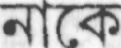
নাকে
